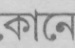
কোনে
